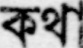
কথা
